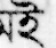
মই
